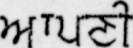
ਆਪਣੀ
